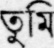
তুমি
